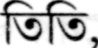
তিতি,
